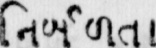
નિર્બળતા
